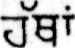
ਹੱਥਾਂ
